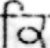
ਕਿ
